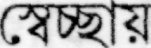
স্বেচ্ছায়
